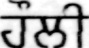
ਹੌਲੀ
